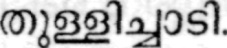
തുള്ളിച്ചാടി.
